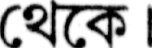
থেকে।
